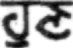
ਹੁਣ
